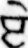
ਏ
